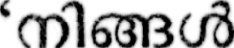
'നിങ്ങള്‍
